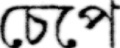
চেপে
